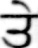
ਤੇ
